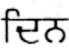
ਦਿਨ
